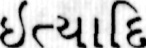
ઈત્યાદિ
